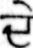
ਦੇ
